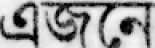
এজনে
